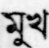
মুখ
